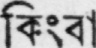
কিংবা
